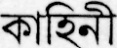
কাহিনী
